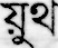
য়ুথ
